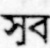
সব
